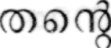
തന്റെ
